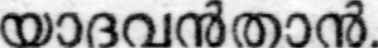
യാദവന്‍താന്‍.
